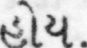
હોય.
